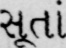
સૂતાં
